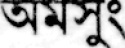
অমসুং
